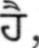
ਹੈ,
